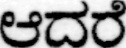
ಆದರೆ
